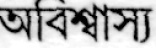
অবিশ্বাস্য
